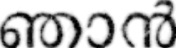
ഞാന്‍
